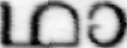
ഥാ
